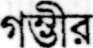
গম্ভীর
